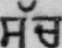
ਸੱਚ
